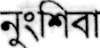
নুংশিবা
